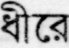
ধীরে
